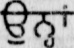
ਉਨ੍ਹਾਂ
